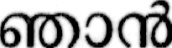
ഞാന്‍
